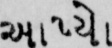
આપ્યો
